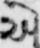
એ
